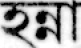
হন্না
